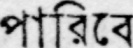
পারিবে
